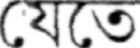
যেতে
